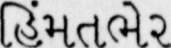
હિંમતભેર
